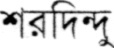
শরদিন্দু
